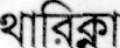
থারিক্না
